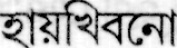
হায়খিবনো
